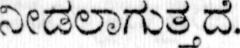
ನೀಡಲಾಗುತ್ತದೆ.
